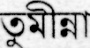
তুমীন্না
